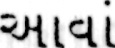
આવાં
